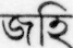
জহি
